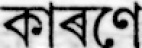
কাৰণে
